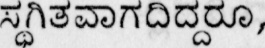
ಸ್ಥಗಿತವಾಗದಿದ್ದರೂ,
